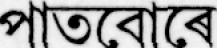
পাতবোৰে
